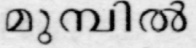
മുമ്പില്‍
